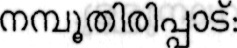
നമ്പൂതിരിപ്പാട്:
